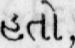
હતો,
